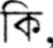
কি,
